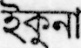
ইকুনা
